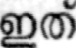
ഇത്
